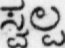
ಸ್ವಲ್ಪ
